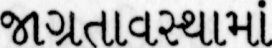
જાગ્રતાવસ્થામાં
